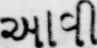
આવી
